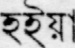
হইয়া
